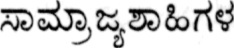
ಸಾಮ್ರಾಜ್ಯಶಾಹಿಗಳ
